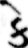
કે
